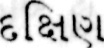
દક્ષિણ
